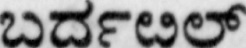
ಬರ್ದೞಲ್
